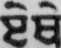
ਏਥੇ
